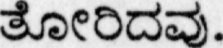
ತೋರಿದವು.
